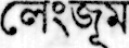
লেংজূম
